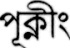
পূক্নীং
